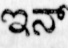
ಇನ್
